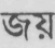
জয়
